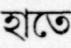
হাতে
